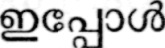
ഇപ്പോള്‍
